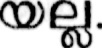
യല്ല.
